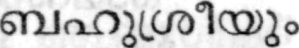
ബഹുശ്രീയും
